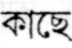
কাছে
